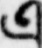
এ
